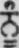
ਨੂੰ
